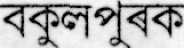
বকুলপুৰক
